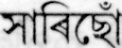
সাৰিছোঁ
